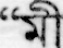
“মী
